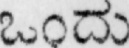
ಒಂದು
